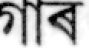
গাৰ
